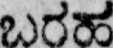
ಬರಹ
